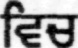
ਵਿਚ
